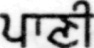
ਪਾਣੀ
